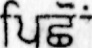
ਪਿਛੋਂ
